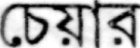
চেয়ার
